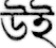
উই
